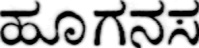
ಹೂಗನಸ
